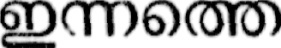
ഇന്നത്തെ
